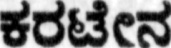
ಕರಟೇನಾ
